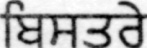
ਬਿਸਤਰੇ
